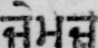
ਜੇਮਜ਼
